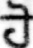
ਹੋ
